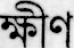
ক্ষীণ
